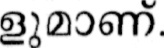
ളുമാണ്.
